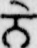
ਨੇ
